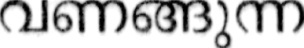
വണങ്ങുന്ന
